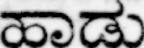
ಹಾಡು
